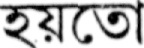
হয়তো
